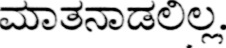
ಮಾತನಾಡಲಿಲ್ಲ.
